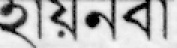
হায়নবা
